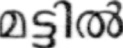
മട്ടില്‍
